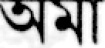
অমা
